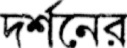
দর্শনের
